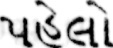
પહેલો
